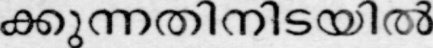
ക്കുന്നതിനിടയില്‍
